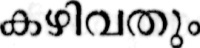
കഴിവതും
